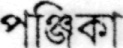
পঞ্জিকা
